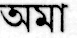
অমা
